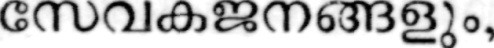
സേവകജനങ്ങളും,
